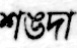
শঙদা
